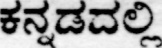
ಕನ್ನಡದಲ್ಲಿ
